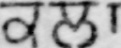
ਕਲਾ
